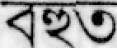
বহুত
